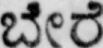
ಬೇರೆ
